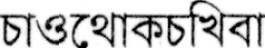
চাওথোকচখিবা
